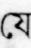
যে
